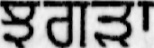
ਝਗੜਾ
